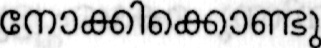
നോക്കിക്കൊണ്ടു
